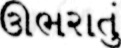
ઊભરાતું
